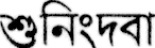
শুনিংদবা
